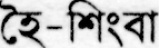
হৈ-শিংবা
